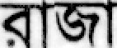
রাজা
